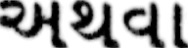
અથવા
